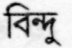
বিন্দু
